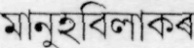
মানুহবিলাকৰ
